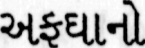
અફઘાનો
